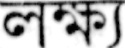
লক্ষ্য
